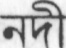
নদী
